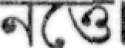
নত্তে।
